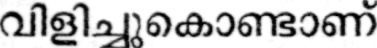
വിളിച്ചുകൊണ്ടാണ്
